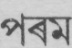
পৰম
